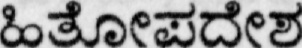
ಹಿತೋಪದೇಶ
